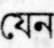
যেন
